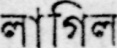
লাগিল
